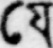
যে
